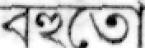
বহুতো
